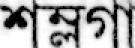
শম্লগা
